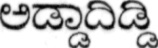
ಅಡ್ಡಾದಿಡ್ಡಿ
